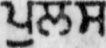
ਪੁਲਸ
